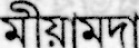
মীয়ামদা
